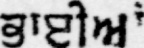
ਭਾਈਆਂ
